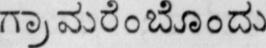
ಗ್ರಾಮರೆಂಬೊಂದು
